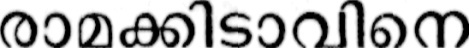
രാമക്കിടാവിനെ
